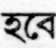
হবে
